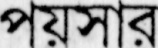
পয়সার
